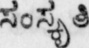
ಸಂಸ್ಕೃತಿ
